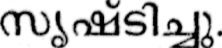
സൃഷ്ടിച്ചു.
